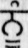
ਨੂੰ
